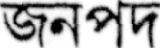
জনপদ
